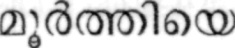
മൂര്‍ത്തിയെ
